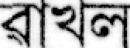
ৱাখল
